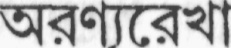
অরণ্যরেখা
